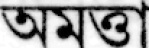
অমত্তা
